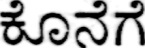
ಕೊನೆಗೆ
